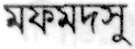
মফমদসু
